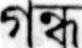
গন্ধ
